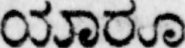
ಯಾರೂ
